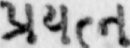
પ્રયત્ન
